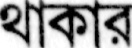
থাকার
